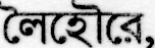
লৈহৌরে,
